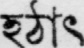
হঠাৎ
